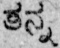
ತನ್ನ
